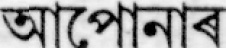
আপোনাৰ
